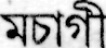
মচাগী
